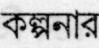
কল্পনার
